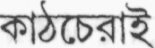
কাঠচেরাই
